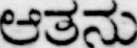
ಆತನು
